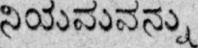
ನಿಯಮವನ್ನು
